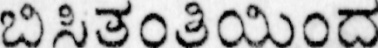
ಬಿಸಿತಂತಿಯಿಂದ
